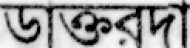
ডাক্তরদা
